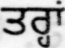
ਤਰ੍ਹਾਂ
